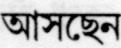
আসছেন
